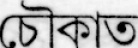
চৌকাত
